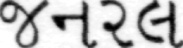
જનરલ
